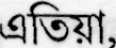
এতিয়া,
